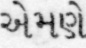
એમણે
